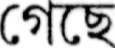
গেছে
